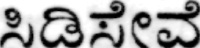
ಸಿಡಿಸೇವೆ
